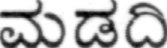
ಮಡದಿ
